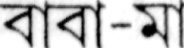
বাবা-মা
